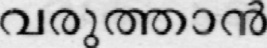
വരുത്താന്‍
